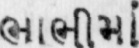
ભાભીમાં
